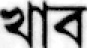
খাব
